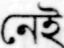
নেই
